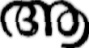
ആ
